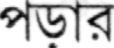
পড়ার
